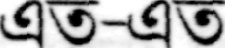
এত-এত
